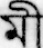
মী
